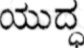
ಯುದ್ಧ
